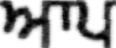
ਆਪ
